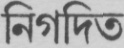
নিগদিত
